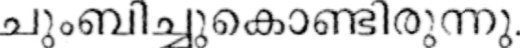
ചുംബിച്ചുകൊണ്ടിരുന്നു.
